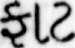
ફાટ
